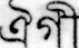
ঐগী
